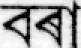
বৰা
